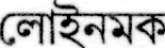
লোইনমক
